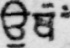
ਉਥੋਂ
